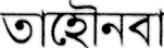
তাহৌনবা
